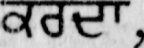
ਕਰਦਾ,
